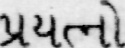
પ્રયત્નો
